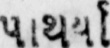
પાથર્યા
